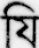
যি
